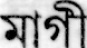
মাগী
